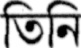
তিনি
